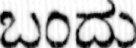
ಬಂದು
